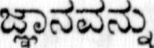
ಜ್ಞಾನವನ್ನು
